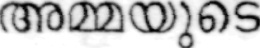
അമ്മയുടെ
